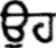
ਉਹ
